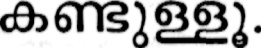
കണ്ടുള്ളൂ.
